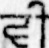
ਵੀ
